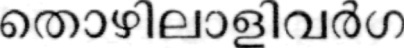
തൊഴിലാളിവര്‍ഗ
